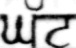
ਘੱਟ
